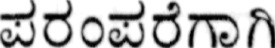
ಪರಂಪರೆಗಾಗಿ
